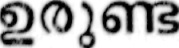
ഉരുണ്ട
